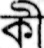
কী
